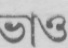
ভাও
